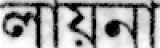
লায়না
